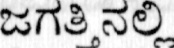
ಜಗತ್ತಿನಲ್ಲಿ
